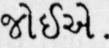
જોઈએ.
